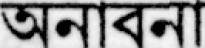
অনাবনা
